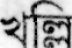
খল্লি
